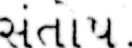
સંતોષ.
